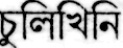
চুলিখিনি
